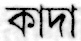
কাদা
